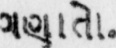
ગણાતો.
